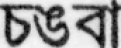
চঙবা
